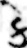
કે
